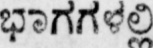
ಭಾಗಗಳಲ್ಲಿ
